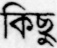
কিছু
